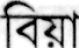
বিয়া
